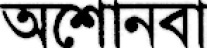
অশোনবা
